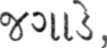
જગાડે,
